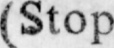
(Stop
